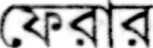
ফেরার
